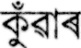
কুঁৱাৰ
